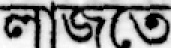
লাজতে
